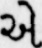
એ
